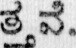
ತ್ತವೆ.
